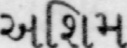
અશિમ
